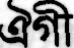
ঐগী
